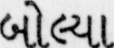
બોલ્યા
